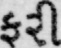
ફરી
